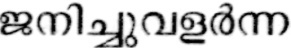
ജനിച്ചുവളര്‍ന്ന
